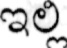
ಇಲ್ಲಿ
